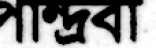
পান্দ্রবা
